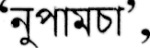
‘নুপামচা’,
